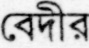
বেদীর
